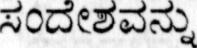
ಸಂದೇಶವನ್ನು
